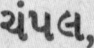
ચંપલ,
